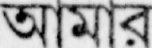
আমার
